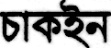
চাকইন
